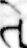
તે
